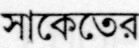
সাকেতের
